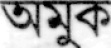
অমুক
